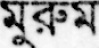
মুরুম
